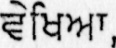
ਵੇਖਿਆ,
